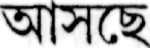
আসছে
